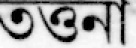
তত্তনা
